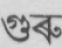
গুৰু
